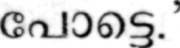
പോട്ടെ.'
